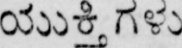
ಯುಕ್ತಿಗಳು
